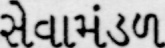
સેવામંડળ
